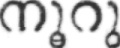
നൂറു
